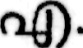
എ.
